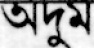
অদুম
